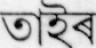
তাইৰ
